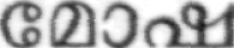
മോഷ
